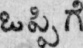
ಒಪ್ಪಿಗೆ
